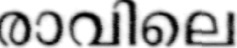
രാവിലെ
